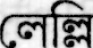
লেল্লি
